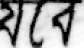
যবে
